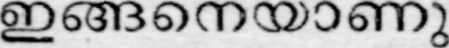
ഇങ്ങനെയാണു
